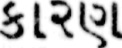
કારણ
